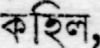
কহিল,
